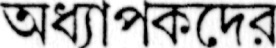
অধ্যাপকদের
